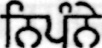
ਨਿਪੰਨੇ
